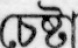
চেষ্টা
